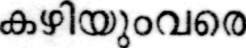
കഴിയുംവരെ
